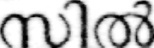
സില്‍
